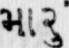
મારું
